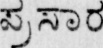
ಪ್ರಸಾರ
